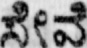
ಸೇವೆ
